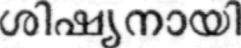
ശിഷ്യനായി
